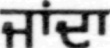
ਜਾਂਦਾ
